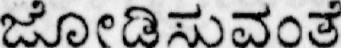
ಜೋಡಿಸುವಂತೆ
